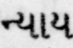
ન્યાય
